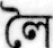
লৈ
